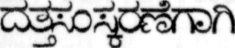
ದತ್ತಸಂಸ್ಕರಣೆಗಾಗಿ
